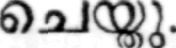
ചെയ്തു.
